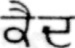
ਕੈਦ
